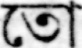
তো
